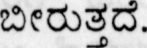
ಬೀರುತ್ತದೆ.
